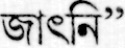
জাৎনি”
